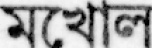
মখোল
